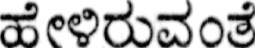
ಹೇಳಿರುವಂತೆ
